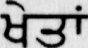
ਖੇਤਾਂ
